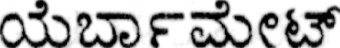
ಯೆರ್ಬಾಮೇಟ್
